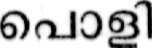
പൊളി
